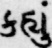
કહ્યું
